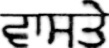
ਵਾਸਤੇ
